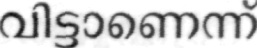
വിട്ടാണെന്ന്
